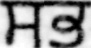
ਸਭ
